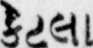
કેટલા
